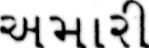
અમારી
